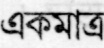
একমাত্র
